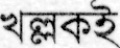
খল্লকই
